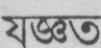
যজ্ঞত
